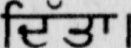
ਦਿੱਤਾ।
